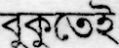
বুকুতেই
